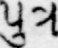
પુત્ર
